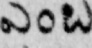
ಎಂಬ
